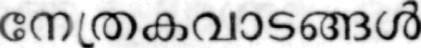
നേത്രകവാടങ്ങള്‍
